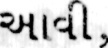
આવી,
